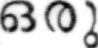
ഒരു
